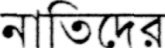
নাতিদের
